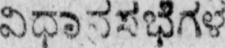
ವಿಧಾನಸಭೆಗಳ
